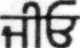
ਜੀਓ
